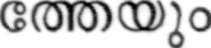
ത്തേയും
